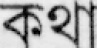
কথা
